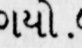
ગયો.
